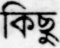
কিছু
